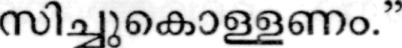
സിച്ചുകൊള്ളണം."
